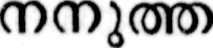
നനുത്ത
